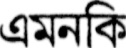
এমনকি
